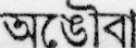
অঙৌবা
